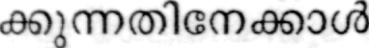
ക്കുന്നതിനേക്കാള്‍
